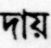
দায়
